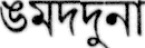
ঙমদদুনা
